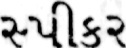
સ્પીકર
